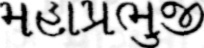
મહાપ્રભુજી
